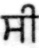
ਸੀ
